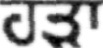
ਹੜਾ
